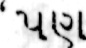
'પણ
